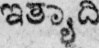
ಇತ್ಯಾದಿ
